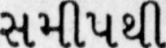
સમીપથી
